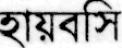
হায়বসি
